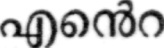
എന്റെ
